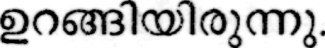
ഉറങ്ങിയിരുന്നു.
